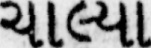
ચાલ્યા
